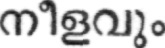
നീളവും
